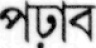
পঢ়াব
